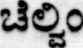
ಚೆಲ್ವಿಂ
